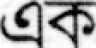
এক
